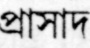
প্রাসাদ
